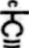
ਨੂੰ
